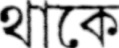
থাকে
